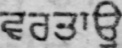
ਵਰਤਾਉ
